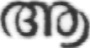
ആ
